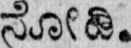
ನೋಡಿ.
